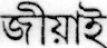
জীয়াই
